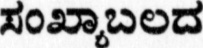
ಸಂಖ್ಯಾಬಲದ
